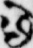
છે?
